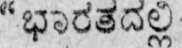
“ಭಾರತದಲ್ಲಿ
